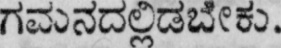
ಗಮನದಲ್ಲಿಡಬೇಕು.
